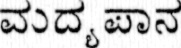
ಮದ್ಯಪಾನ
